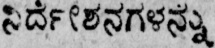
ನಿರ್ದೇಶನಗಳನ್ನು
